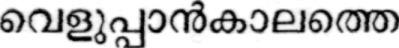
വെളുപ്പാന്‍കാലത്തെ
